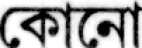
কোনো
